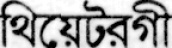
থিয়েটরগী
